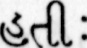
હતી:
